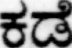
ಕಡೆ
